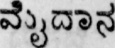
ಮೈದಾನ
